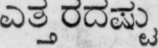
ಎತ್ತರದಷ್ಟು
